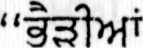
''ਭੈੜੀਆਂ
